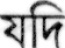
যদি
